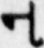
ન
